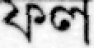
ফল
